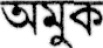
অমুক
